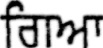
ਗਿਆ
